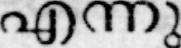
എന്നു
